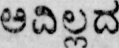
ಅದಿಲ್ಲದ
